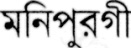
মনিপুরগী
